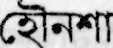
হৌনশা
